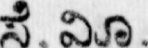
ಸೆ.ಮೀ.
